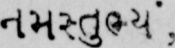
નમસ્તુભ્યં,
